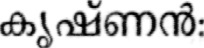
കൃഷ്ണന്‍:
